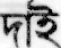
দাই
